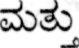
ಮತ್ತು
